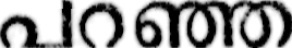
പറഞ്ഞ
